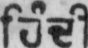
ਹਿੰਦੀ
